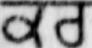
ਕਰ
